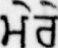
ਮੇਰੇ
